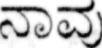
ನಾವು
